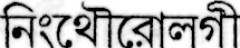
নিংথৌরেলগী
